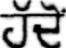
ਹੱਦੋਂ
